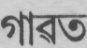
গাৱত
